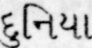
દુનિયા
